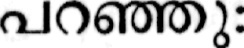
പറഞ്ഞു:
